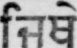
ਜਿਥੇ
